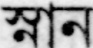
স্নান
